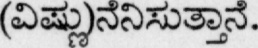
(ವಿಷ್ಣು)ನೆನಿಸುತ್ತಾನೆ.
